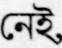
নেই,
